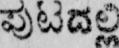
ಪುಟದಲ್ಲಿ
